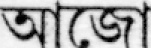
আজো
